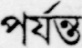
পর্যন্ত
